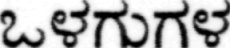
ಒಳಗುಗಳ
